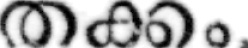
തക്കം.
